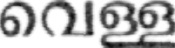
വെള്ള
